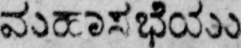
ಮಹಾಸಭೆಯು
